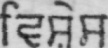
ਵਿਸ਼ੇਸ
